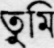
তুমি
